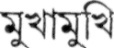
মুখামুখি
